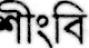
শীংবি
